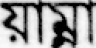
য়াম্না
